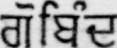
ਗੋਬਿੰਦ
